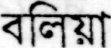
বলিয়া
